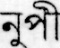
নুপী
